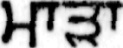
ਮਾੜਾ
